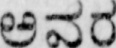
ಅವರ
